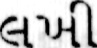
લખી
